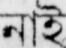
নাই
